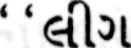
"લીગ
